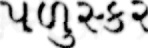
પળુસ્કર
